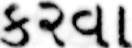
કરવા
